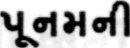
પૂનમની
